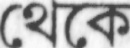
থেকে
